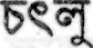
চৎলু
